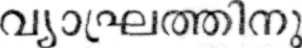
വ്യാഘ്രത്തിനു
